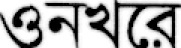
ওনখরে
